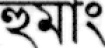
হুমাং
